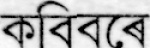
কবিবৰে
